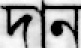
দান
